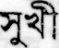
সুখী
